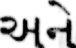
અને
